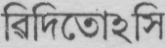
ৱিদিতোহসি
